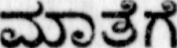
ಮಾತೆಗೆ
